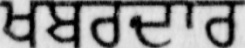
ਖਬਰਦਾਰ
